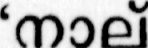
‘നാല്
